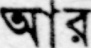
আর
